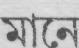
মানে
